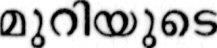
മുറിയുടെ
